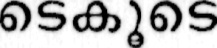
ടെകൂടെ
